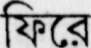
ফিরে
